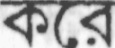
করে
